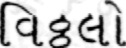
વિઠ્ઠલો
